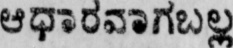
ಆಧಾರವಾಗಬಲ್ಲ
